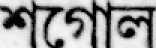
শগোল
